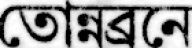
তোন্নব্রনে
